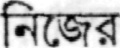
নিজের
